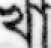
খা
